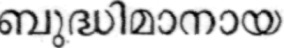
ബുദ്ധിമാനായ
